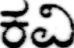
ಕವಿ
